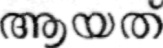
ആയത്
